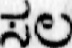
ಸಲ
